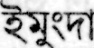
ইমুংদা
